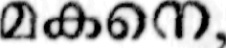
മകനെ,
